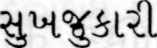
સુખજુકારી
